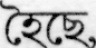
হৈছে,
